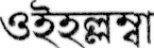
ওইহল্লম্বা
